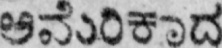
ಅಮೆರಿಕಾದ
